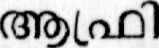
ആഫ്രി
